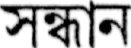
সন্ধান
